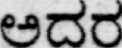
ಅದರ
